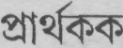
প্ৰাৰ্থকক
